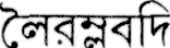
লৈরম্লবদি
